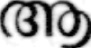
ആ
